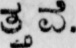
ತ್ತವೆ.
